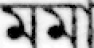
মমা
